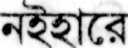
নইহারে
